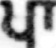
ਪਾ
